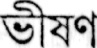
ভীষণ
